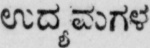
ಉದ್ಯಮಗಳ
